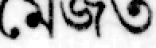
মেজত
